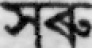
সৰু
